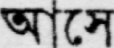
আসে
